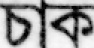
চাক
